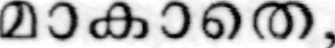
മാകാതെ,
